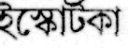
ইস্কোর্টকা
